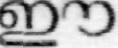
ഈ
